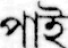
পাই
